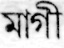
মাগী
